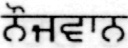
ਨੌਜਵਾਨ
